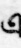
এ
